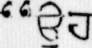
''ਉਹ
